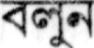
বলুন
